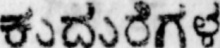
ಕುದುರೆಗಳ
